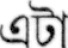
এটা
